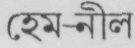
হেম-নীল
